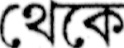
থেকে
